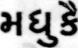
મધુકૈ
